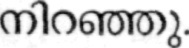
നിറഞ്ഞു.
